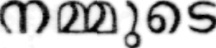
നമ്മുടെ
